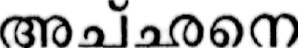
അച്ഛനെ
